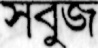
সবুজ
